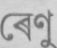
ৰেণু
